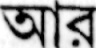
আর
